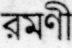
রমণী
